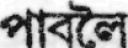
পাবলৈ
